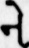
ને
